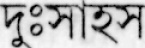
দুঃসাহস
